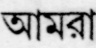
আমরা
